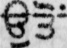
ਉਤੋਂ
